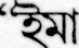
“ইমা
